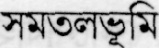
সমতলভূমি
